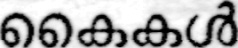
കൈകള്‍
